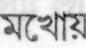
মখোয়
